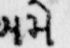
અમે
